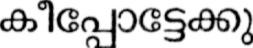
കീപ്പോട്ടേക്കു
